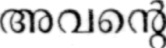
അവന്റെ
